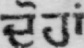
ਦੋਹਾਂ
